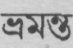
ভ্ৰমন্ত
